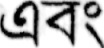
এবং
